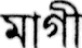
মাগী
